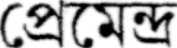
প্রেমেন্দ্র
